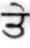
ਤੇ
